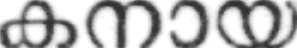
കനായ
